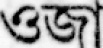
ওজা
